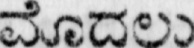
ಮೊದಲು
